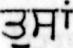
ਤੁਸਾਂ
